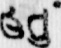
હતું
